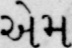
એમ
